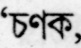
‘চণক,
